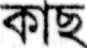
কাছ
